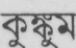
কুঙ্কুম
